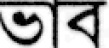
ভাব
